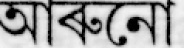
আৰুনো
